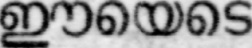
ഈയെടെ
